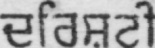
ਦਰਿਸ਼ਟੀ
